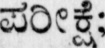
ಪರೀಕ್ಷೆ;
